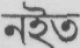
নইত
